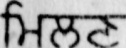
ਮਿਲਣ
